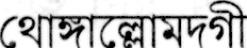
থোঙ্গাল্লোমদগী
